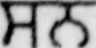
ਸਨ
